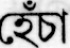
হেঁচা
